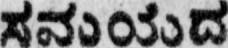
ಸಮಯದ
